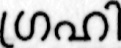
ഗ്രഹി
